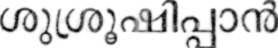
ശുശ്രൂഷിപ്പാന്‍
